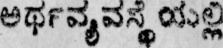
ಅರ್ಥವ್ಯವಸ್ಥೆಯಲ್ಲಿ
